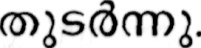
തുടര്‍ന്നു.
